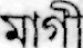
মাগী
